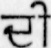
ਦੀ
